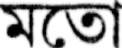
মতো
